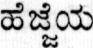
ಹೆಜ್ಜೆಯ
